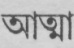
আত্মা
